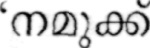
‘നമുക്ക്
